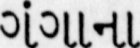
ગંગાના
